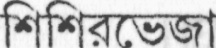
শিশিরভেজা
